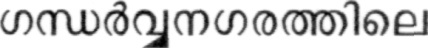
ഗന്ധര്‍വ്വനഗരത്തിലെ
